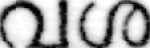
വശ
